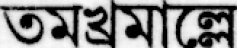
তমখ্রমাল্লে
